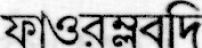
ফাওরম্লবদি
